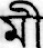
মী
